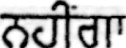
ਨਹੀਂਗਾ
